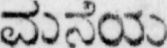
ಮನೆಯ
